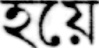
হয়ে
